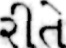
રીતે
